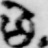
છે.
